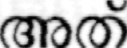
അത്
